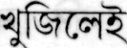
খুজিলেই
